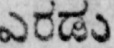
ಎರಡು
